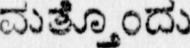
ಮತ್ತೊಂದು
